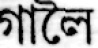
গালৈ
